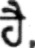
ਹੈ,
